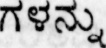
ಗಳನ್ನು
